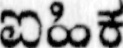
ಐಹಿಕ
